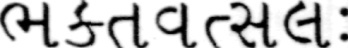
ભક્તવત્સલઃ
